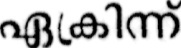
ഏക്രിന്ന്
